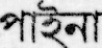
পাইনা
